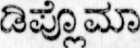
ಡಿಪ್ಲೊಮಾ
